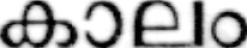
കാലം
